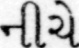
નીચે
